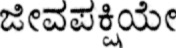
ಜೀವಪಕ್ಷಿಯೇ
